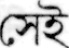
সেই
